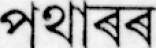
পথাৰৰ
